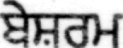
ਬੇਸ਼ਰਮ
